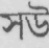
সউ
